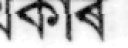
থকাৰ
